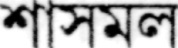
শাসমল
